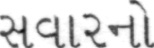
સવારનો
